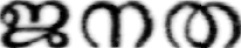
ജനത
